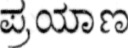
ಪ್ರಯಾಣ
